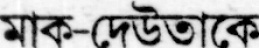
মাক-দেউতাকে
